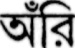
অঁরি
